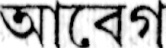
আবেগ
